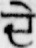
ਦੇ
